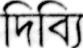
দিব্যি
